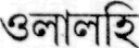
ওলালহি
